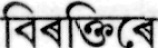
বিৰক্তিৰে
